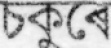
চকুৰে
